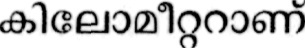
കിലോമീറ്ററാണ്
